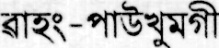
ৱাহং-পাউখুমগী
